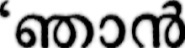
‘ഞാന്‍
